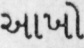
આખો
